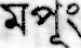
মপুং
